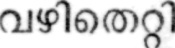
വഴിതെറ്റി
